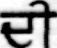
ਦੀ
